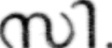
സി.
